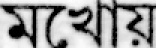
মখোয়
